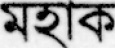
মহাক
